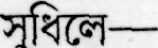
সুধিলে-
